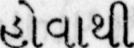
હોવાથી
